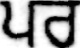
ਪਰ
